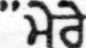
''ਮੇਰੇ
